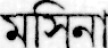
মসিনা
